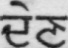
ਦੇਣ
